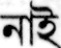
নাই
